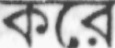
করে
